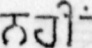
ਨਹੀਂ
